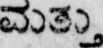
ಮತ್ತು
